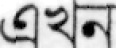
এখন
